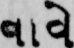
વાવે
